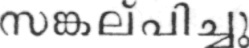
സങ്കല്പിച്ചു
